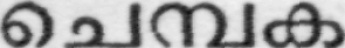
ചെമ്പക
